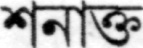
শনাক্ত
